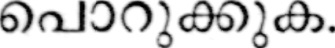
പൊറുക്കുക.
